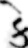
કે
